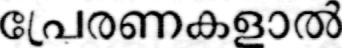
പ്രേരണകളാല്‍
